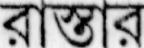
রাস্তার
